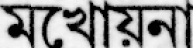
মখোয়না
